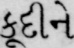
કૂદીને
